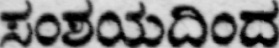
ಸಂಶಯದಿಂದ
